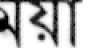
ময়া
